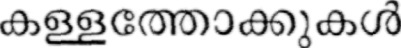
കള്ളത്തോക്കുകള്‍
